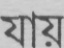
যায়
